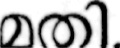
മതി.
